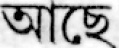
আছে
